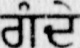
ਗੰਦੇ
